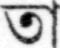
তা
